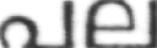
പല
